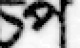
চপ
